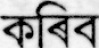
কৰিব
